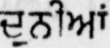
ਦੁਨੀਆਂ
